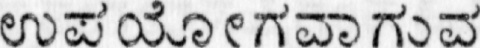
ಉಪಯೋಗವಾಗುವ
